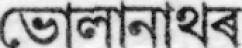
ভোলানাথৰ
